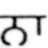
ਨਾ
